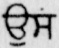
ਉਸ
